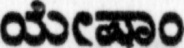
ಯೇಷಾಂ
